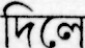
দিলে
